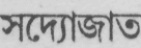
সদ্যোজাত
